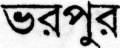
ভরপুর
